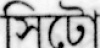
সিটো
